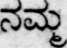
ನಮ್ಮ
